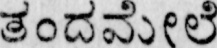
ತಂದಮೇಲೆ
